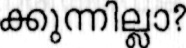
ക്കുന്നില്ലാ?
